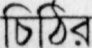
চিঠির
